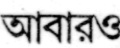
আবারও
